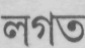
লগত
